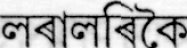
লৰালৰিকৈ
